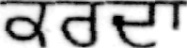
ਕਰਦਾ
